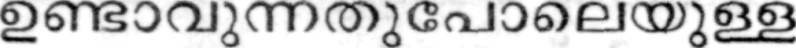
ഉണ്ടാവുന്നതുപോലെയുള്ള
